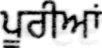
ਪੂਰੀਆਂ
